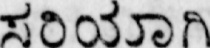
ಸರಿಯಾಗಿ
